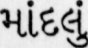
માંદલું
